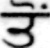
ਤੋਂ
